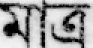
মাত্র
